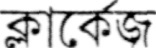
ক্লার্কেজ
